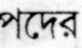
পদের
